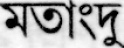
মতাংদু
